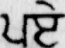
ਪਏ
